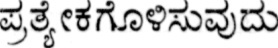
ಪ್ರತ್ಯೇಕಗೊಳಿಸುವುದು
